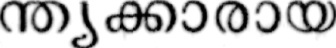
ന്ത്യക്കാരായ
